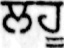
ਲਹੂ
